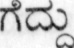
ಗೆದ್ದು
